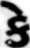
કે
